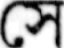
সে
